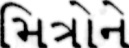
મિત્રોને
